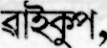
ৱাইকুপ,
